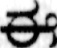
ಈ
